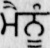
ਮੈਨੂੰ
